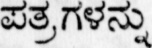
ಪತ್ರಗಳನ್ನು
